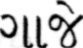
ગાજે
